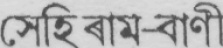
সেহিৰাম-বাণী
